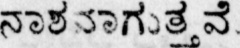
ನಾಶವಾಗುತ್ತವೆ.
